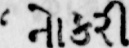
'નોકરી
